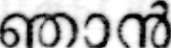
ഞാന്‍
